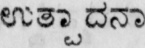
ಉತ್ಪಾದನಾ
